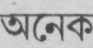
অনেক
